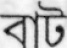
বাট
